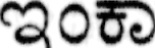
ಇಂಕಾ
